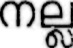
നല്ല
